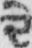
ਦੇ
